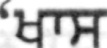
'ਖਾਸ
